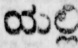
ಯಲ್ಲಿ
